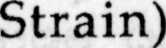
Strain)
